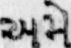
અમે
